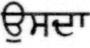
ਉਸਦਾ
